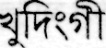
খুদিংগী
